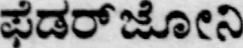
ಫೆಡರ್‌ಜೋನಿ
